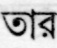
তার
